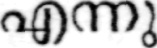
എന്നു
